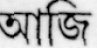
আজি
